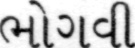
ભોગવી
